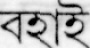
বহাই
